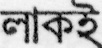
লাকই
